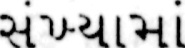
સંખ્યામાં
